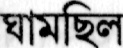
ঘামছিল
